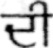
ਦੀ
